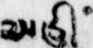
અહીં
